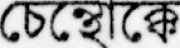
চেন্থোক্কে
